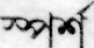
স্পর্শ
